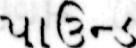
પાઉન્ડ
